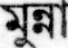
মুন্না
